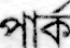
পার্ক
